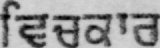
ਵਿਚਕਾਰ
